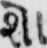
શો
